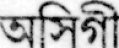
অসিগী
